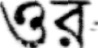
ওর
